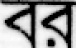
বর
